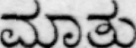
ಮಾತು
